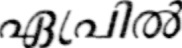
ഏപ്രില്‍
